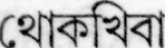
থোকখিবা
